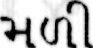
મળી
